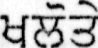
ਖਲੋਤੇ
